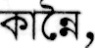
কান্নৈ,
